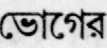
ভোগের
